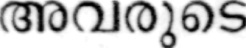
അവരുടെ
